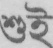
শুই
